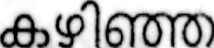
കഴിഞ്ഞ
